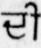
ਦੀ
